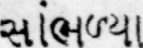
સાંભળ્યા
